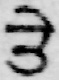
ਤੇ
